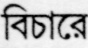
বিচারে
